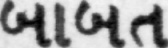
બાબત
